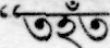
"তহঁত
